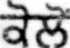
ਕੋਲੋਂ
